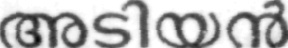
അടിയന്‍
